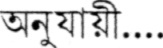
অনুযায়ী....
